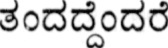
ತಂದದ್ದೆಂದರೆ
